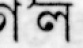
গ'ল
